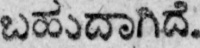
ಬಹುದಾಗಿದೆ.
